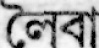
লৈবা
